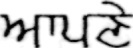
ਆਪਣੇ
